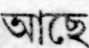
আছে
